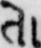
તો
